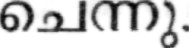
ചെന്നു.
